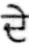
ਦੇ
